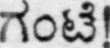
ಗಂಟೆ!
